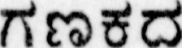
ಗಣಕದ
